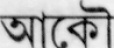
আকৌ
